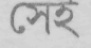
সেই
